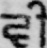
ਵੀ
